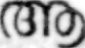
ആ
